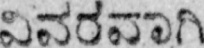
ವಿವರವಾಗಿ
